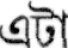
এটা
